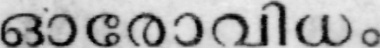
ഓരോവിധം
